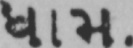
ધામ.
